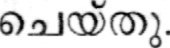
ചെയ്തു.
